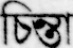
চিন্তা
